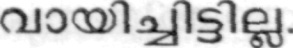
വായിച്ചിട്ടില്ല.
